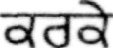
ਕਰਕੇ
